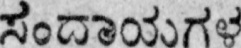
ಸಂದಾಯಗಳ
